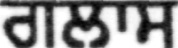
ਗਲਾਸ
